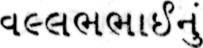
વલ્લભભાઈનું
